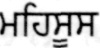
ਮਹਿਸੂਸ
